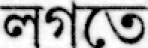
লগতে
